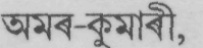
অমৰ-কুমাৰী,
